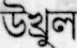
উখ্রুল
